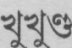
খুখুণ্ড
